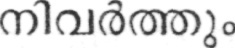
നിവര്‍ത്തും
